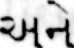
અને
